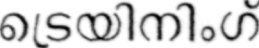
ട്രെയിനിംഗ്
